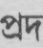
প্ৰদ
